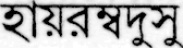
হায়রম্বদুসু
